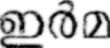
ഇര്‍മ
